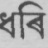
ধৰি
